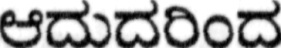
ಆದುದರಿ೦ದ
